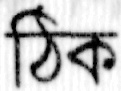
ঠিক
